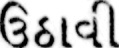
ઉઠાવી
